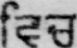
ਵਿਚ
